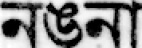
নঙনা
